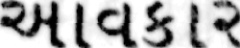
આવકાર
